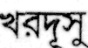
খরদূসু
